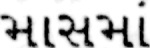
માસમાં
